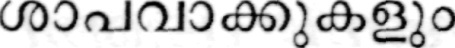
ശാപവാക്കുകളും
